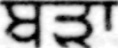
ਬੜਾ
